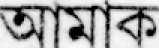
আমাক
